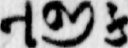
નજીક
